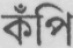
কঁপি
